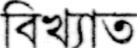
বিখ্যাত
